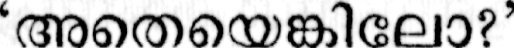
'അതെയെങ്കിലോ?'
